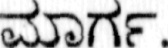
ಮಾರ್ಗ.
